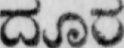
ದೂರ
